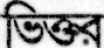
ভিক্তর
